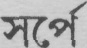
সৰ্পে
